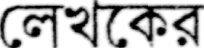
লেখকের
